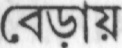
বেড়ায়
